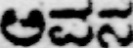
ಅವನ
